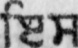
ਇਸ
